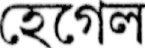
হেগেল
